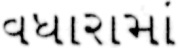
વધારામાં
